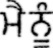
ਮੈਨੂੰ
